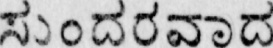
ಸುಂದರವಾದ
